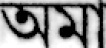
অমা
